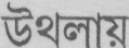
উথলায়
